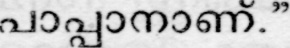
പാപ്പാനാണ്."
